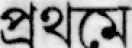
প্রথমে
